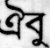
ঐবু
